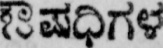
ಔಷಧಿಗಳ
